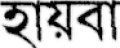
হায়বা
